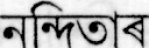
নন্দিতাৰ
